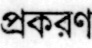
প্রকরণ
